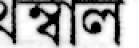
থম্বাল
